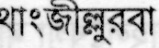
থাংজীল্লুরবা
